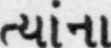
ત્યાંના
